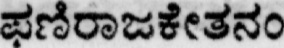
ಫಣಿರಾಜಕೇತನಂ
